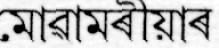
মোৱামৰীয়াৰ
